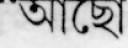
"আছো
